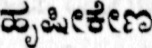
ಹೃಷೀಕೇಣ
